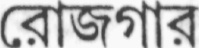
রোজগার
